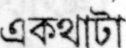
একথাটা
